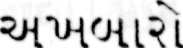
અખબારો
